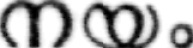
നയം
